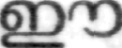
ഈ
